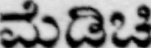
ಮೆಡಿಚಿ
